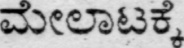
ಮೇಲಾಟಕ್ಕೆ
